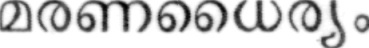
മരണധൈര്യം
